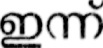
ഇന്ന്
